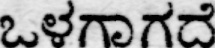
ಒಳಗಾಗದೆ
